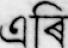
এৰি
